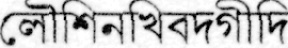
লৌশিনখিবদগীদি
